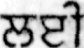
ਲਈ
